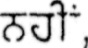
ਨਹੀਂ,
